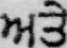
ਅਤੇ
